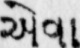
એવા
